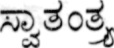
ಸ್ವಾತಂತ್ರ್ಯ
